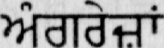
ਅੰਗਰੇਜ਼ਾਂ
